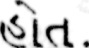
હોત.
